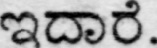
ಇದಾರೆ.
